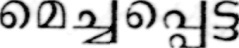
മെച്ചപ്പെട്ട
